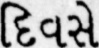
દિવસે
